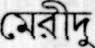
মেরীদু
